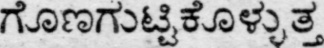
ಗೊಣಗುಟ್ಟಿಕೊಳ್ಳುತ್ತ
